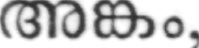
അങ്കം,
